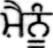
ਮੈਨੂੰ
